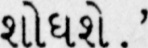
શોધશે.'
